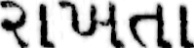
રાખતા
